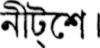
নীট্‌শে।
